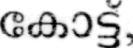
കോട്ട്,
